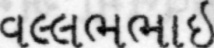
વલ્લભભાઈ
